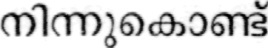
നിന്നുകൊണ്ട്
